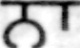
ਨਾ
